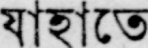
যাহাতে
